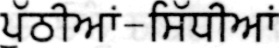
ਪੁੱਠੀਆਂ-ਸਿੱਧੀਆਂ
